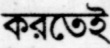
করতেই
